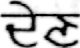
ਦੇਣ
